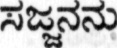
ಸಜ್ಜನನು
